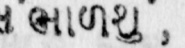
સંભાળશું,
